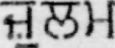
ਜ਼ੁਲਮ
